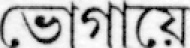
ভোগায়ে
